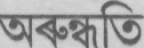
অৰুন্ধতি
